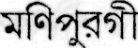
মণিপুরগী
